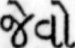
જેવો
